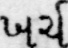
ખર્ચ
